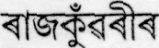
ৰাজকুঁৱৰীৰ
